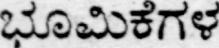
ಭೂಮಿಕೆಗಳ
